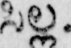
ಸಿಲ್ಲ.
